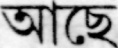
আছে
